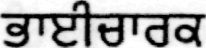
ਭਾਈਚਾਰਕ
